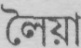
লৈয়া
